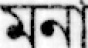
মনা
